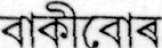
বাকীবোৰ
